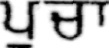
ਪੁਚਾ
